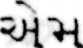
એમ
